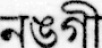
নঙগী
